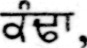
ਕੰਢਾ,
